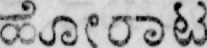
ಹೋರಾಟ
